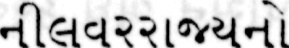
નીલવરરાજ્યનો
